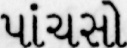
પાંચસો
